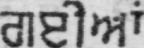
ਗਈਆਂ
